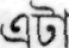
এটা
